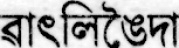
ৱাৎলিঙৈদা
